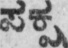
ಪಕ್ಷ
